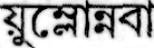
য়ুম্লোন্নবা
